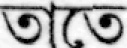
তাতে
